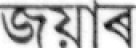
জয়াৰ
